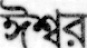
ঈশ্বর
